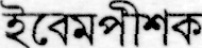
ইবেমপীশক
